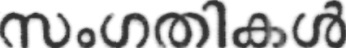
സംഗതികള്‍
